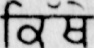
ਕਿੱਥੇ
